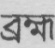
ব্ৰহ্ম
